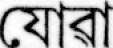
যোৱা
